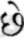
છે
